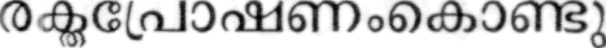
രക്തപ്രോഷണംകൊണ്ടു
